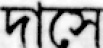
দাসে
